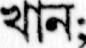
খান;
